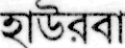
হাউরবা
